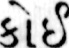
કોઈ
